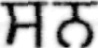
ਸਨ
